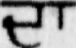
ਦਾ
